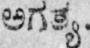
ಅಗತ್ಯ.
